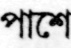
পাশে
